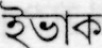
ইভাক
